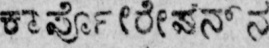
ಕಾರ್ಪೋರೇಷನ್‌ನ
